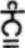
ਨੂੰ
